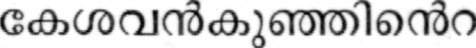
കേശവന്‍കുഞ്ഞിന്റെ
